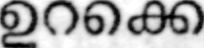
ഉറക്കെ
